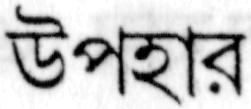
উপহার
